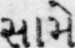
સામે
